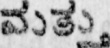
ಮತ್ತು
